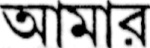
আমার
